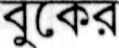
বুকের
